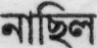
নাছিল
